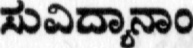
ಸುವಿದ್ಯಾನಾಂ
